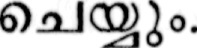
ചെയ്യും.
